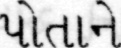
પોતાને
